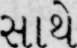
સાથે
